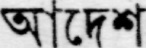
আদেশ
